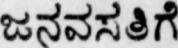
ಜನವಸತಿಗೆ
